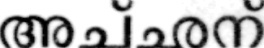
അച്ഛന്
